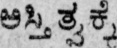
ಅಸ್ತಿತ್ವಕ್ಕೆ
